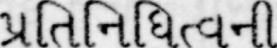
પ્રતિનિધિત્વની
